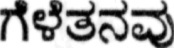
ಗೆಳೆತನವು
